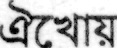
ঐখোয়
